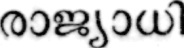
രാജ്യാധി
